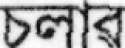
চলাৱ
